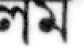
লম
